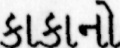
કાકાનો
